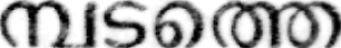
മ്പടത്തെ
